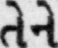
તેને
